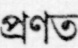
প্রণত
